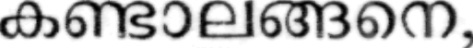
കണ്ടാലങ്ങനെ,
